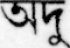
অদু
